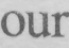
our
